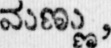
ಮಣ್ಣು,
